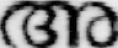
അ
